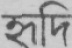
হৃদি
